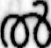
ല്‍
